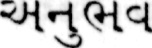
અનુભવ
